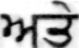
ਅਤੇ
